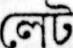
লেট
